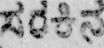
ಸರಕಿನ
